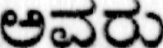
ಅವರು
